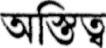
অস্তিত্ব
